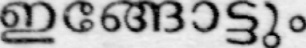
ഇങ്ങോട്ടും
